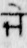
ਜੇ
